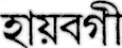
হায়বগী
